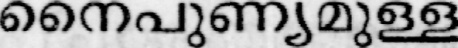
നൈപുണ്യമുള്ള
